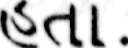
હતા.
